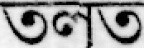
তলত
